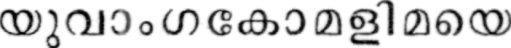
യുവാംഗകോമളിമയെ
